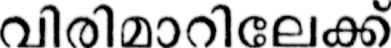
വിരിമാറിലേക്ക്
